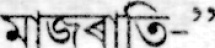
মাজৰাতি-"
